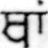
ਥਾਂ
